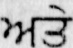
ਅਤੇ
